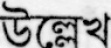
উল্লেখ
